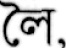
লৈ
